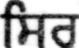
ਸਿਰ
